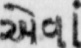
એવાં
